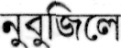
নুবুজিলে
